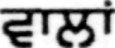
ਵਾਲਾਂ
